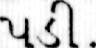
પડી.
